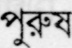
পুরুষ
